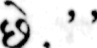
છે."
